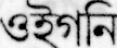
ওইগনি
